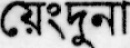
য়েংদুনা
